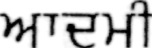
ਆਦਮੀ
